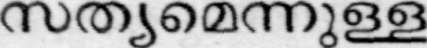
സത്യമെന്നുളള
